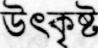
উৎকৃষ্ট
